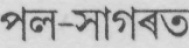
পল-সাগৰত
